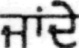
ਜਾਂਦੇ
